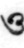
ও
